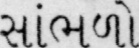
સાંભળો
